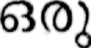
ഒരു
